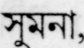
সুমনা,
